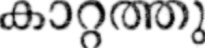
കാറ്റത്തു
